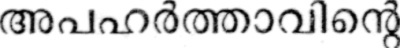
അപഹര്‍ത്താവിന്റെ
